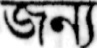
জন্য
